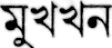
মুখখন
